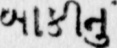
બાકીનું
